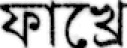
ফাখ্রে
